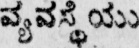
ವ್ಯವಸ್ಥೆಯು
